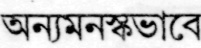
অন্যমনস্কভাবে
